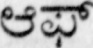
ಆಫ್
